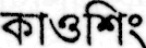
কাওশিং
